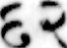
દર
